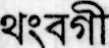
থংবগী
